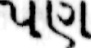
પણ
